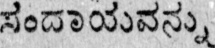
ಸಂದಾಯವನ್ನು
